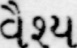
વૈશ્ય
